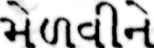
મેળવીને
